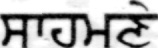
ਸਾਹਮਣੇ
